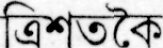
ত্রিশতকৈ
